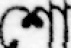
শো
